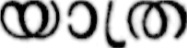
യാത്ര
